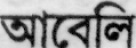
আবেলি
